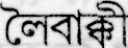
লৈবাক্কী
